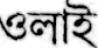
ওলাই
